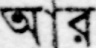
আর
